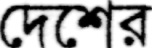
দেশের
